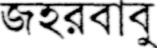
জহরবাবু
